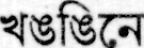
খঙঙিনে
